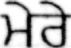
ਮੇਰੇ
